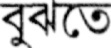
বুঝতে
